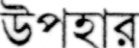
উপহার
